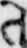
તે
